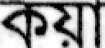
কয়া
